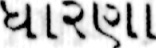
ધારણા
